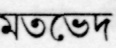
মতভেদ
